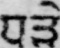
ਧੜੇ
